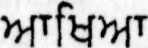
ਆਖਿਆ
